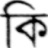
কি
